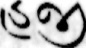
હજી
